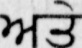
ਅਤੇ
